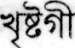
খৃষ্টগী
